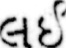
લઈ
